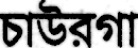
চাউরগা
